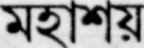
মহাশয়
